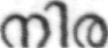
നിര
